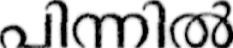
പിന്നില്‍
